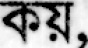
কয়,
